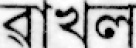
ৱাখল
